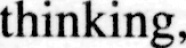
thingking,
